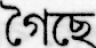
গৈছে
